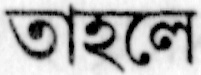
তাহলে
